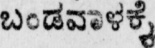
ಬಂಡವಾಳಕ್ಕೆ
